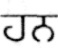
ਹਨ
